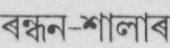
ৰন্ধন-শালাৰ
